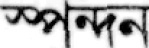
স্পন্দন
